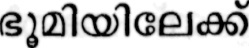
ഭൂമിയിലേക്ക്
